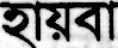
হায়বা
